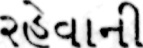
રહેવાની
